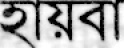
হায়বা
